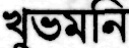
খুভমনি
